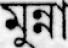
মুন্না
